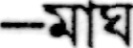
–মাঘ
